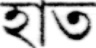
হাত
